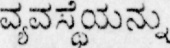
ವ್ಯವಸ್ಥೆಯನ್ನು
